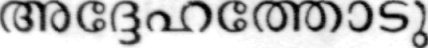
അദ്ദേഹത്തോടു
